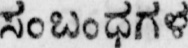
ಸಂಬಂಧಗಳ
